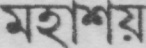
মহাশয়
